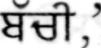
ਬੱਚੀ,'
